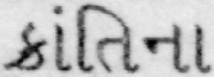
ક્રાંતિના
